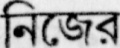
নিজের
